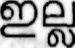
ഇല്ല
